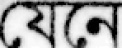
যেনে
